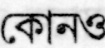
কোনও
